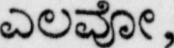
ಎಲವೋ,
